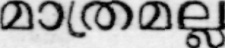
മാത്രമല്ല
